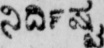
ನಿರ್ದಿಷ್ಟ
